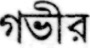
গভীর
